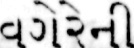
વગેરેની
